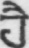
ਹੈ
